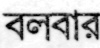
বলবার
